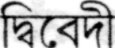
দ্বিবেদী
